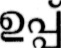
ഉപ്പ്
